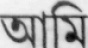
আমি
